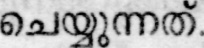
ചെയ്യുന്നത്.
